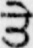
ਤੇ
